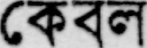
কেবল
